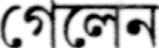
গেলেন
